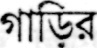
গাড়ির
